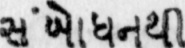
સંબોધનથી
